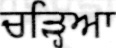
ਚੜ੍ਹਿਆ
